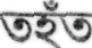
তহঁত
